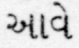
આવે
